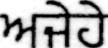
ਅਜੇਹੇ
